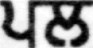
ਪਲ
